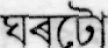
ঘৰটো
